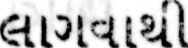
લાગવાથી
